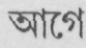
আগে
